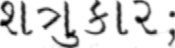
શત્રુકાર;
